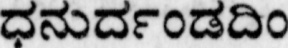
ಧನುರ್ದಂಡದಿಂ
